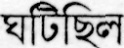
ঘটিছিল
